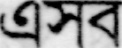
এসব
